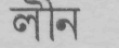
লীন
